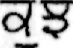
ਕੁਝ
